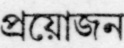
প্রয়োজন
